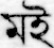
মই
